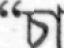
"চা
